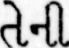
તેની
